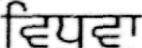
ਵਿਧਵਾ
